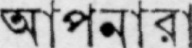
আপনারা
